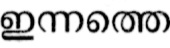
ഇന്നത്തെ
